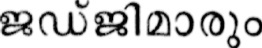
ജഡ്ജിമാരും
